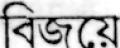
বিজয়ে
